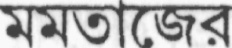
মমতাজের
